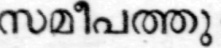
സമീപത്തു
